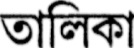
তালিকা
